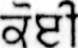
ਕੋਈ
